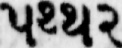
પથ્થર
